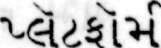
પ્લૅટફૉર્મ
